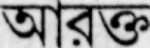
আরক্ত
